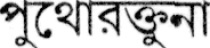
পুথোরক্তুনা
